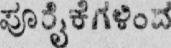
ಪೂರೈಕೆಗಳಿಂದ
